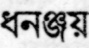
ধনঞ্জয়
